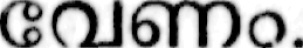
വേണം.
